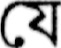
যে
